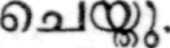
ചെയ്തു.
